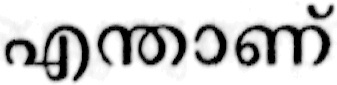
എന്താണ്
